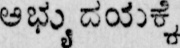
ಅಭ್ಯುದಯಕ್ಕೆ
